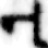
ન
